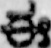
ಈ
